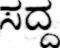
ಸದ್ದ
